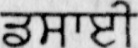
ਡਸਾਈ
